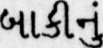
બાકીનું
